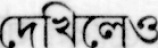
দেখিলেও
